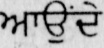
ਆਉਂਦੇ
